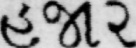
હજાર
